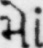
મોં
